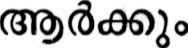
ആര്‍ക്കും
